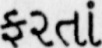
ફરતાં
